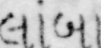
લાંબા
